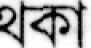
থকা
